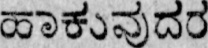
ಹಾಕುವುದರ
